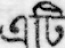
এটি
